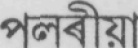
পলৰীয়া
